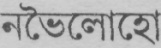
নভৈলোহো
